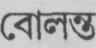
বোলন্ত
